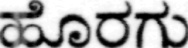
ಹೊರಗು
